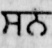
ਸਨ
